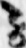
કે
